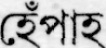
হেঁপাহ
